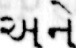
અને
